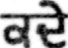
ਕਦੇ
